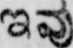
ಇವು
